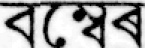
বম্বেৰ
